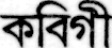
কবিগী
